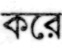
করে
